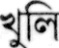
খুলি
